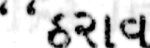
"ઠરાવ
